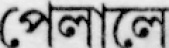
পেলালে
